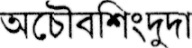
অচৌবশিংদুদা
